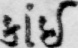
કાંઈ
